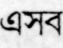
এসব
